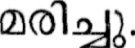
മരിച്ചു.
